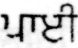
ਪਾਈ
